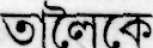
তালৈকে
